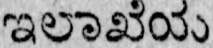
ಇಲಾಖೆಯ
